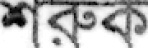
শরুক
